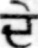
ਦੇ
